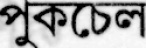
পুকচেল
